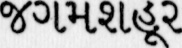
જગમશહૂર
